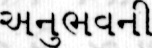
અનુભવની
